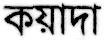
কয়াদা
